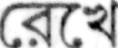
রেখে
